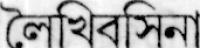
লৈখিবসিনা
